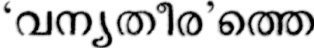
‘വന്യതീര'ത്തെ
